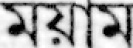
ময়াম
